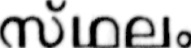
സ്ഥലം
